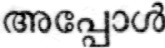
അപ്പോള്‍
